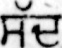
ਸੱਦ
